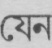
যেন
